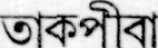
তাকপীবা
